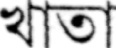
খাতা
